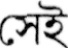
সেই
